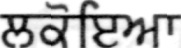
ਲਕੋਇਆ
